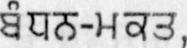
ਬੰਧਨ-ਮਕਤ,
